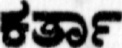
ಕರ್ತಾ
